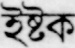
ইষ্টক
